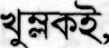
খুম্লকই,
